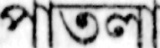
পাতলা
